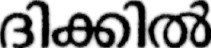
ദിക്കില്‍
